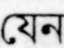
যেন
